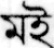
মই
